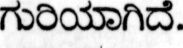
ಗುರಿಯಾಗಿದೆ.
